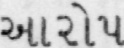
આરોપ
